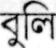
বুলি
